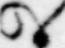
જ
